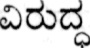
ವಿರುದ್ಧ
